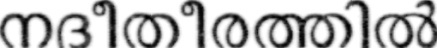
നദീതീരത്തില്‍
